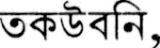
তকউবনি,
